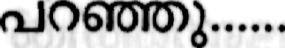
പറഞ്ഞു......
